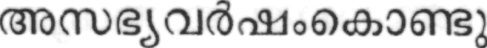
അസഭ്യവര്‍ഷംകൊണ്ടു
